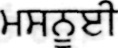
ਮਸਨੂਈ
